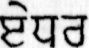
ਏਧਰ
